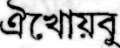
ঐখোয়বু
